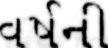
વર્ષની
